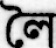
লৈ
